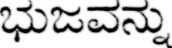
ಭುಜವನ್ನು
